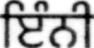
ਇੰਨੀ
